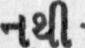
નથી
